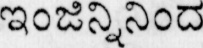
ಇಂಜಿನ್ನಿನಿಂದ
